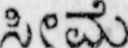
ಸೀಮೆ
